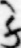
કે
